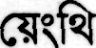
য়েংথি
